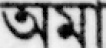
অমা
